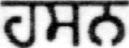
ਹਸਨ
